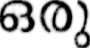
ഒരു
